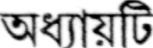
অধ্যায়টি
